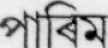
পাৰিম
